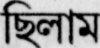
ছিলাম
